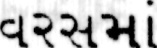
વરસમાં
